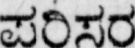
ಪರಿಸರ
